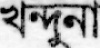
খন্দুনা
